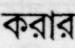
করার
